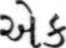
એક
